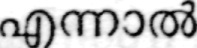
എന്നാല്‍
